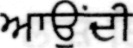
ਆਉਂਦੀ
